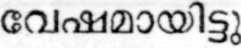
വേഷമായിട്ടു
